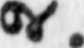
જ.
